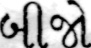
બીજો
